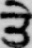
ਤੇ
